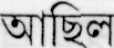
আছিল
